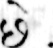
છે.
